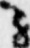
કે
